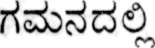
ಗಮನದಲ್ಲಿ
